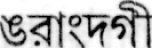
ঙরাংদগী
